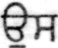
ਉਸ
